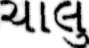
ચાલુ
